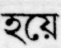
হয়ে
